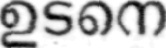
ഉടനെ
